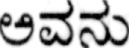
ಅವನು
